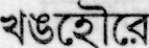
খঙহৌরে
